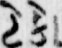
ટેકો
